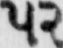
પર
